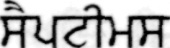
ਸੈਪਟੀਮਸ
